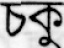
চকু
